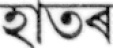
হাতৰ
